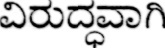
ವಿರುದ್ಧವಾಗಿ
